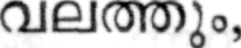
വലത്തും,
